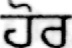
ਹੋਰ
